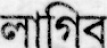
লাগিব
